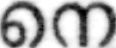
നെ
